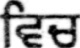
ਵਿਚ
